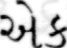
એક
